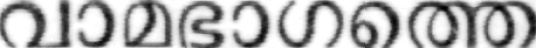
വാമഭാഗത്തെ
